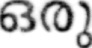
ഒരു
